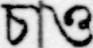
চাও
